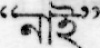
"নাই"
